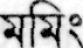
মমিং
